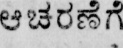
ಆಚರಣೆಗೆ
